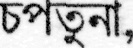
চপতুনা,
